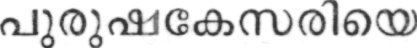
പുരുഷകേസരിയെ
